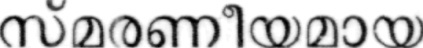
സ്മരണീയമായ
